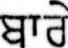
ਬਾਰੇ
